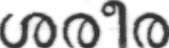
ശരീര
